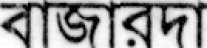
বাজারদা
